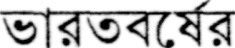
ভারতবর্ষের
